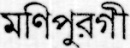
মণিপুরগী
